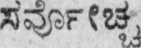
ಸರ್ವೋಚ್ಚ
